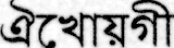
ঐখোয়গী
